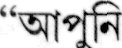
"আপুনি
